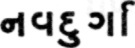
નવદુર્ગા
